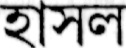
হাসল
